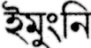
ইমুংনি
